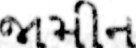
જામીન
